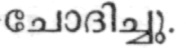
ചോദിച്ചു.
